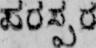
ಪರಸ್ಪರ
